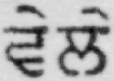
ਵੇਲੇ
